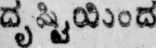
ದೃಷ್ಟಿಯಿಂದ
